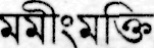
মমীংমক্তি
